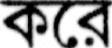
করে
